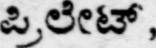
ಪ್ರಿಲೇಟ್,
